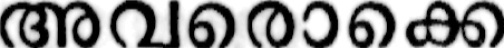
അവരൊക്കെ
